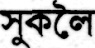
সুকলৈ
